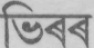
ভিৰৰ
